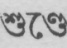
শুণ্ডে
